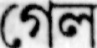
গেল
